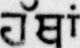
ਹੱਥਾਂ
